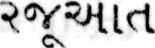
રજૂઆત
